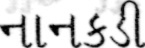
નાનકડી
